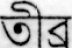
তীব্র
